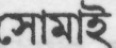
সোমাই
